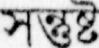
সন্তুষ্ট
